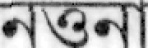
নত্তনা
